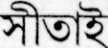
সীতাই
